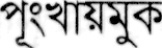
পূংখায়মুক
